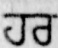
ਹਰ
